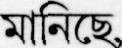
মানিছে,
